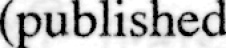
(published
